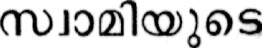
സ്വാമിയുടെ
